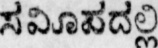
ಸಮೀಪದಲ್ಲಿ
